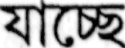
যাচ্ছে
